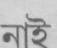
নাই
